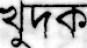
খুদক
